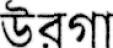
উরগা
